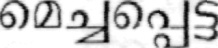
മെച്ചപ്പെട്ട
